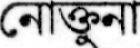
নোক্তুনা
